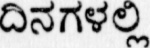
ದಿನಗಳಲ್ಲಿ
